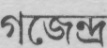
গজেন্দ্ৰ
